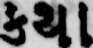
કથા
